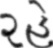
રહે
